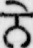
ਨੇ
